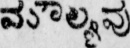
ಮೌಲ್ಯವು
